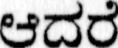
ಆದರೆ
